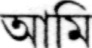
আমি
